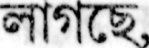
লাগছে,
